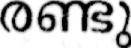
രണ്ടു
